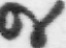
જ
